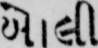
બોલી
